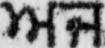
ਅਜ
